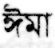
ঈমা
